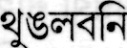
থুঙলবনি
